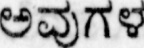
ಅವುಗಳ
